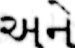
અને
